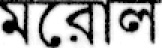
মরোল
